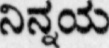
ನಿನ್ನಯ
